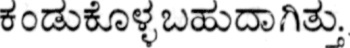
ಕಂಡುಕೊಳ್ಳಬಹುದಾಗಿತ್ತು.
